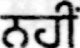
ਨਹੀਂ
